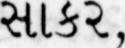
સાકર,
